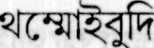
থম্মোইবুদি
